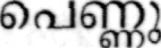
പെണ്ണു
